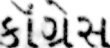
કૉંગ્રેસ
